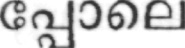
പ്പോലെ
